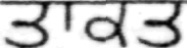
ਤਾਕਤ
